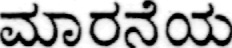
ಮಾರನೆಯ
